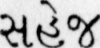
સહેજ
